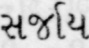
સર્જાય
